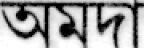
অমদা
